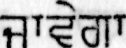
ਜਾਵੇਗਾ
